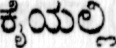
ಕೈಯಲ್ಲಿ
